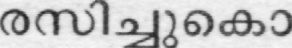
രസിച്ചുകൊ
